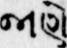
જાણે
